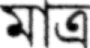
মাত্র
